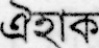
ঐহাক
